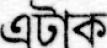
এটাক
